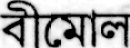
বীমোল
